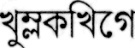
খুম্লকখিগে
